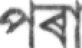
পৰা
